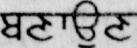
ਬਣਾਉਣ
